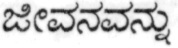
ಜೀವನವನ್ನು
